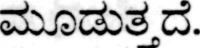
ಮೂಡುತ್ತದೆ.
